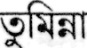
তুমিন্না
